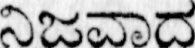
ನಿಜವಾದ
